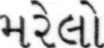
મરેલો
